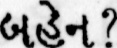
બહેન?
